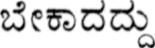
ಬೇಕಾದದ್ದು
